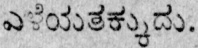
ಎಳೆಯತಕ್ಕುದು.
